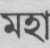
মহা
